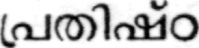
പ്രതിഷ്ഠ
